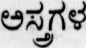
ಅಸ್ತ್ರಗಳ
